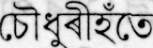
চৌধুৰীহঁতে
